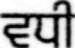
ਵਧੀ
